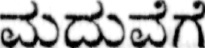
ಮದುವೆಗೆ
